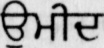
ਉਮੀਦ
